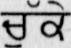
ਚੁੱਕੇ
